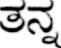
ತನ್ನ
